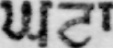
ਘਟਾ
